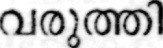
വരുത്തി
